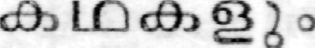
കഥകളും
